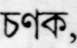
চণক,
